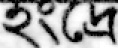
হংদ্রে
